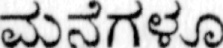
ಮನೆಗಳೂ
